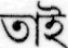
তাই
